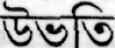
উভতি
